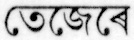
তেজেৰে
